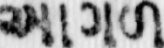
આગળ
